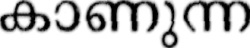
കാണുന്ന
